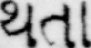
થના
